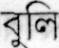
বুলি
